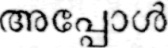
അപ്പോള്‍
